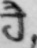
ਹੈ,
